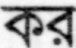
কর
